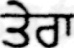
ਤੇਰਾ
